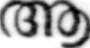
ആ
